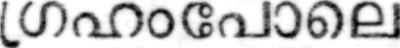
ഗ്രഹംപോലെ
